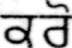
ਕਰੋ
